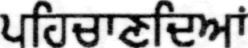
ਪਹਿਚਾਣਦਿਆਂ
